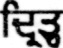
ਦ੍ਰਿੜ੍ਹ
